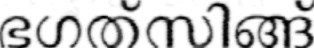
ഭഗത്‌സിങ്ങ്
